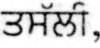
ਤਸੱਲੀ,
